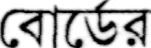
বোর্ডের
